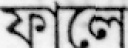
ফালে
